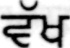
ਵੱਖ
